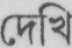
দেখি
